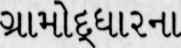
ગ્રામોદધારના
